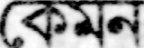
কেমন
